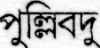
পুল্লিবদু
